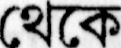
থেকে
